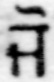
ਜੋ
